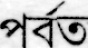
পর্বত
